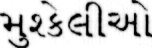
મુશ્કેલીઓ
